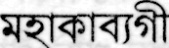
মহাকাব্যগী
